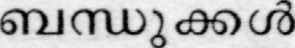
ബന്ധുക്കള്‍
